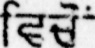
ਵਿਚੋਂ
